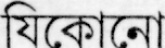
যিকোনো
